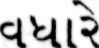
વધારે
